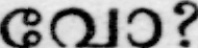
വോ?
